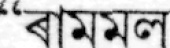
"ৰামমল
